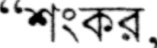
“শংকর,
